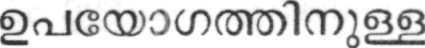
ഉപയോഗത്തിനുള്ള
